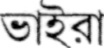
ভাইরা
